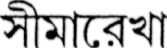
সীমারেখা
